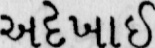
અદેખાઈ
